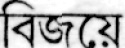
বিজয়ে
